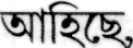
আহিছে,
